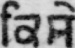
ਕਿਸੇ
